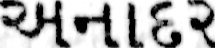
અનાદર
